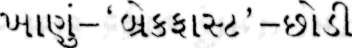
ખાણું-'બ્રેકફાસ્ટ'-છોડી
